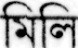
মিলি
